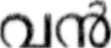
വന്‍
